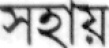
সহায়
